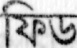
ফিড
